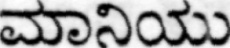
ಮಾನಿಯು
